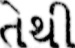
તેથી
